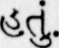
હતું.
